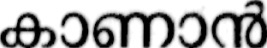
കാണാന്‍
